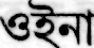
ওইনা
